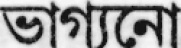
ভাগ্যনো
